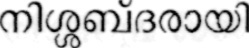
നിശ്ശബ്ദരായി
